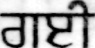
ਗਈ
